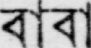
বাবা
